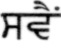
ਸਵੈਂ
